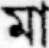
মা
